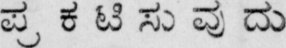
ಪ್ರಕಟಿಸುವುದು
